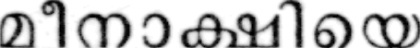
മീനാക്ഷിയെ
